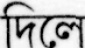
দিলে
